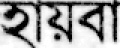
হায়বা
